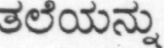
ತಲೆಯನ್ನು
